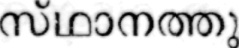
സ്ഥാനത്തു
